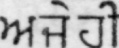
ਅਜੇਹੀ
